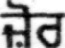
ਜ਼ੋਰ
